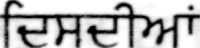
ਦਿਸਦੀਆਂ
